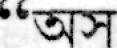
“অস
